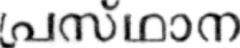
പ്രസ്ഥാന
